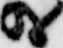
જ
